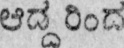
ಆದ್ದರಿಂದ
